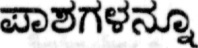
ಪಾಶಗಳನ್ನೂ
